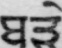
ਬੜੇ
